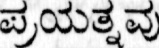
ಪ್ರಯತ್ನವು
